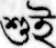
শুই
